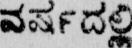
ವರ್ಷದಲ್ಲಿ
